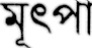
মূৎপা
